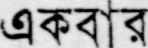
একবার
